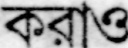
করাও
